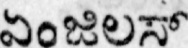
ಏಂಜಿಲಸ್
